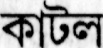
কাটল
